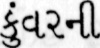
કુંવરની
